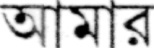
আমার
